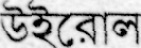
উইরোল
